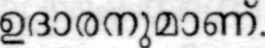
ഉദാരനുമാണ്.
